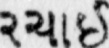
રચાઈ
